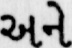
અને
